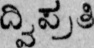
ದ್ವಿಪ್ರತಿ
